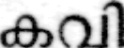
കവി
